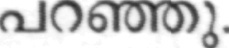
പറഞ്ഞു.
